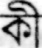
কী
